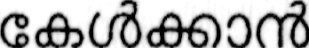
കേള്‍ക്കാന്‍
